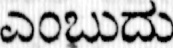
ಎಂಬುದು
